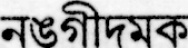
নঙগীদমক
